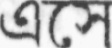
এসে
